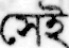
সেই
